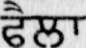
ਫੈਲਾ
